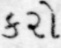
કરો
